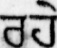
ਰਹੇ
